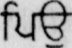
ਪਿਉ
